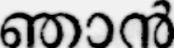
ഞാന്‍
